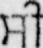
ਸੀ
